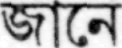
জানে
